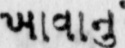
ખાવાનું
